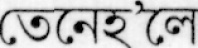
তেনেহ'লে
